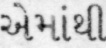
એમાંથી
